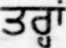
ਤਰ੍ਹਾਂ
